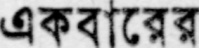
একবারের
